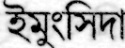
ইমুংসিদা
